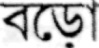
বড়ো
